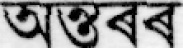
অন্তৰৰ
